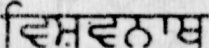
ਵਿਸ਼ਵਨਾਥ
